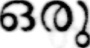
ഒരു
